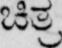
ಚಿತ್ರ
